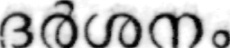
ദര്‍ശനം
